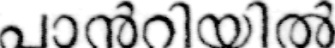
പാന്റിയില്‍
